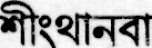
শীংথানবা
